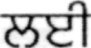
ਲਈ
